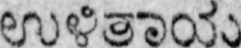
ಉಳಿತಾಯ
